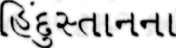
હિંદુસ્તાનના
